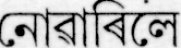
নোৱাৰিলে
